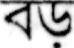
বড়
